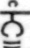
ਨੂੰ
